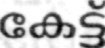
കേട്ട്
